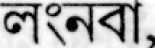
লংনবা,
